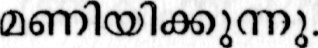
മണിയിക്കുന്നു.
